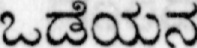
ಒಡೆಯನ
